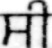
ਸੀ
